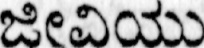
ಜೀವಿಯು
